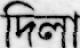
দিলা
